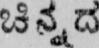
ಚಿನ್ನದ
